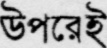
উপরেই
